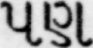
પણ
